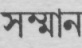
সম্মান
